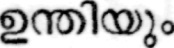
ഉന്തിയും
